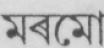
মৰমো
